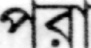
পরা
